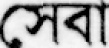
সেবা
